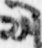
એ
